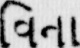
વિના
